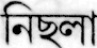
নিছলা
